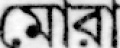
মোরা
